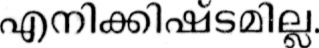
എനിക്കിഷ്ടമില്ല.
